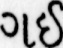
ગઈ
